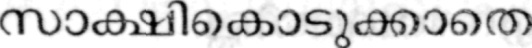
സാക്ഷികൊടുക്കാതെ
